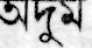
অদুম
